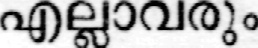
എല്ലാവരും
